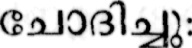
ചോദിച്ചു:
